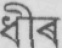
ধীৰ
